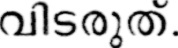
വിടരുത്.
